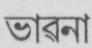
ভাৱনা
